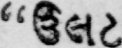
“ઉલટ
